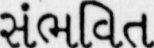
સંભવિત
